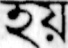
হয়
